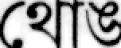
থোঙ
